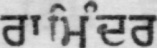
ਰਾਮਿੰਦਰ
